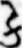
કે
